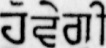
ਹੋਵੇਗੀ
